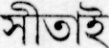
সীতাই
